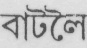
বাটলৈ
